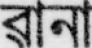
ৱানা
